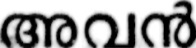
അവന്‍
